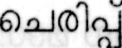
ചെരിപ്പ്
